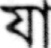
যা
